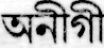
অনীগী
